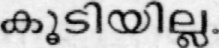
കൂടിയില്ല.
